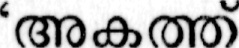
‘അകത്ത്
